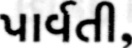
પાર્વતી,
